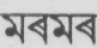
মৰমৰ
